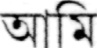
আমি
